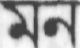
মন
